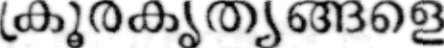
ക്രൂരകൃത്യങ്ങളെ
